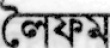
লৈফম
